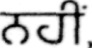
ਨਹੀਂ,
